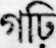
গঢ়ি
